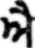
ਐ
